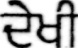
ਦੇਖੀ
